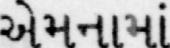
એમનામાં
